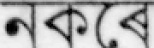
নকৰে
